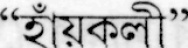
"হাঁয়কলী"
